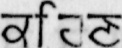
ਕਹਿਣ
